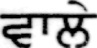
ਵਾਲੇ
